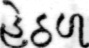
હેઠળ
